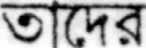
তাদের
